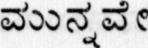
ಮುನ್ನವೇ
